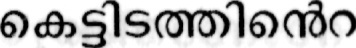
കെട്ടിടത്തിന്റെ
